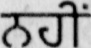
ਨਹੀਂ
